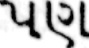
પણ
